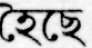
হৈছে
